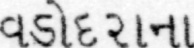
વડોદરાના
